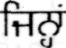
ਜਿਨ੍ਹਾਂ
